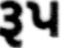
રૂપ
